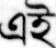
এই
